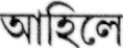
আহিলে
